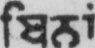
ਬਿਨਾਂ
